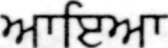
ਆਇਆ
